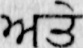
ਅਤੇ
